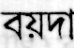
বয়দা
